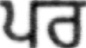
ਪਰ
